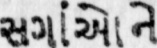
સગાંઓને
